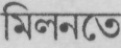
মিলনতে
